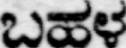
ಬಹಳ
